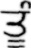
ਤੂੰ
